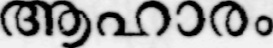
ആഹാരം
